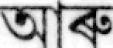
আৰু
